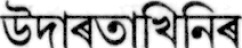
উদাৰতাখিনিৰ
